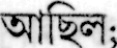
আছিল;
